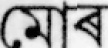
মোৰ
